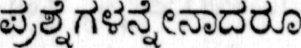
ಪ್ರಶ್ನೆಗಳನ್ನೇನಾದರೂ
